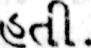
હતી.
